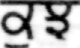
ਕੁਝ
